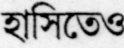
হাসিতেও
